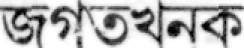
জগতখনক
